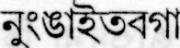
নুংঙাইতবগা
